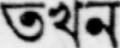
তখন
